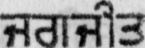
ਜਗਜੀਤ
